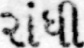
રાંધી
